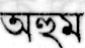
অহুম
